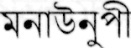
মনাউনুপী
